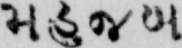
મહજબ
